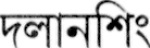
দলানশিং
